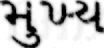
મુખ્ય
